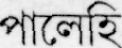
পালেহি
